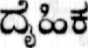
ದೈಹಿಕ
